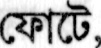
ফোটে,
